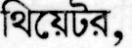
থিয়েটর,
